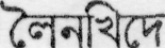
লৈনখিদে
